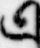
এ
